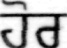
ਹੋਰ
